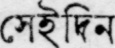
সেইদিন
